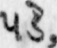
પડે,
